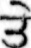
ਤੇ
